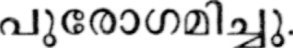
പുരോഗമിച്ചു.
